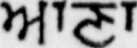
ਆਣਾ
